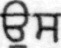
ਉਸ
